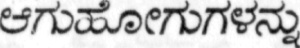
ಆಗುಹೋಗುಗಳನ್ನು
